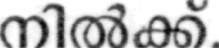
നില്‍ക്ക്.
